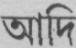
আদি
